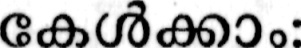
കേള്‍ക്കാം:
